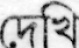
দেখি
